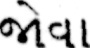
જોવા
